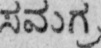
ಸಮಗ್ರ
